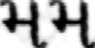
મમ
